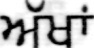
ਅੱਖਾਂ
